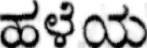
ಹಳೆಯ
